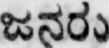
ಜನರು
